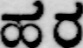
ಹರ
